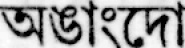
অঙাংদো
